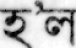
হ'ল
